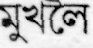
মুখলৈ
